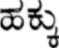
ಹಕ್ಕು
